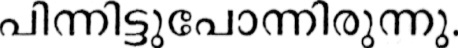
പിന്നിട്ടുപോന്നിരുന്നു.
